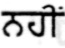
ਨਹੀਂ
